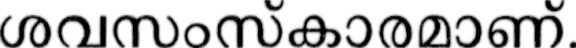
ശവസംസ്കാരമാണ്.
